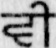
ਵੀ
